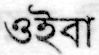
ওইবা
